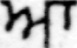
ਆ
